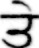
ਤੇ
